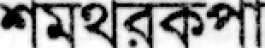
শমথরকপা
